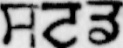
ਸਟਡ
